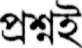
প্রশ্নই
